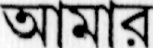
আমার
